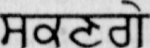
ਸਕਣਗੇ
